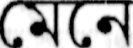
মেনে
